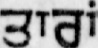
ਤਾਰਾਂ
